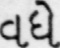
વધે
